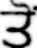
ਤੋਂ
